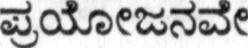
ಪ್ರಯೋಜನವೇ
